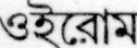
ওইরোম
